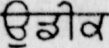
ਉਡੀਕ
